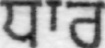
ਧਾਰ
